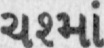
ચશ્માં
